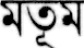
মতূম
